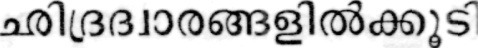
ഛിദ്രദ്വാരങ്ങളില്‍ക്കൂടി
